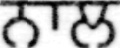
ਨਾਲ
